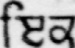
ਇਕ
